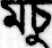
মচু
